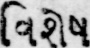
વિશેષ
